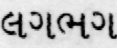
લગભગ
